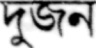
দুজন
